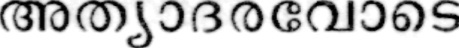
അത്യാദരവോടെ
